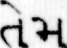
તેમ
